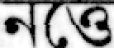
নত্তে
